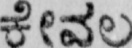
ಕೇವಲ
